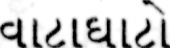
વાટાઘાટો
